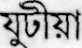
যুটীয়া
